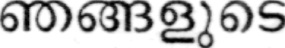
ഞങ്ങളുടെ
